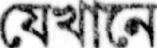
যেখানে
